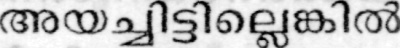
അയച്ചിട്ടില്ലെങ്കില്‍
